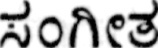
ಸಂಗೀತ
